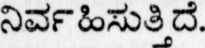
ನಿರ್ವಹಿಸುತ್ತಿದೆ.
